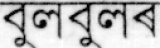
বুলবুলৰ
